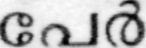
പേര്‍
